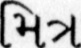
મિત્ર
